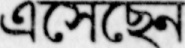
এসেছেন
